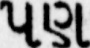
પણ
